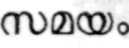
സമയം
